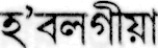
হ'বলগীয়া
